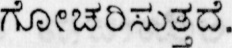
ಗೋಚರಿಸುತ್ತದೆ.
